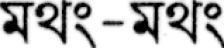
মথং-মথং
